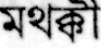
মথক্কী
